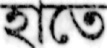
হাতে
